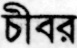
চীবর
